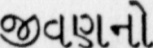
જીવણનો
